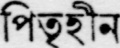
পিতৃহীন
